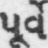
પૂર્વે
